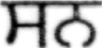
ਸਨ
